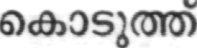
കൊടുത്ത്
